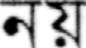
নয়
